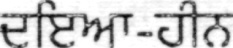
ਦਇਆ-ਹੀਨ
